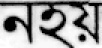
নহয়
